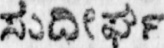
ಸುದೀರ್ಘ
